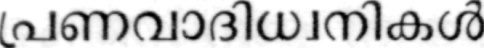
പ്രണവാദിധ്വനികള്‍
